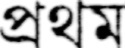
প্রথম
